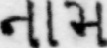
નામ
